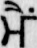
ਮੈਂ
